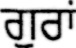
ਗੁਰਾਂ
